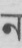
ন
